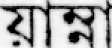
য়াম্না
